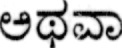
ಅಥವಾ
